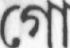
গো
